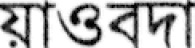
য়াওবদা
